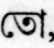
তো,
